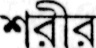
শরীর
